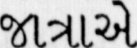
જાત્રાએ
